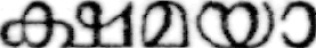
ക്ഷമയാ
